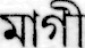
মাগী
